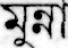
মুন্না
